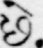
છે.
